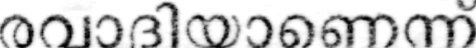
രവാദിയാണെന്ന്
